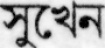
সুখেন
